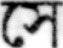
সে
